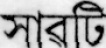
সাৱটি
